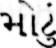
મોટું
